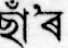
ছাঁ'ৰ
